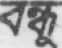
বন্ধু
